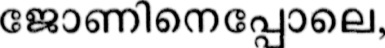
ജോണിനെപ്പോലെ,
